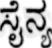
ಸೈನ್ಯ
